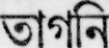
তাগনি
